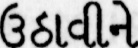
ઉઠાવીને
